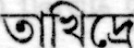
তাখিদ্রে
